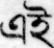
এই
